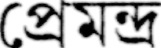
প্রেমন্দ্র
